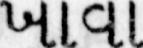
ખાવા
